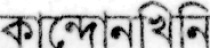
কান্দোনখিনি
